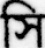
সি
